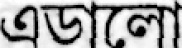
এডালো
